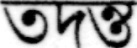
তদন্ত
